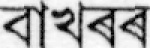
বাখৰৰ
